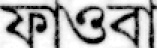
ফাওবা
